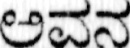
ಅವನ
